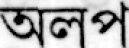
অলপ
